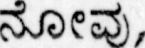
ನೋವು,
